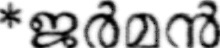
*ജര്‍മന്‍
